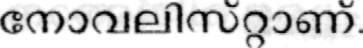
നോവലിസ്റ്റാണ്.
